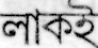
লাকই
